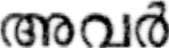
അവര്‍
